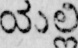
ಯಲ್ಲಿ
